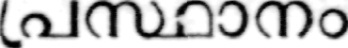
പ്രസ്ഥാനം
